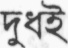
দুধই
